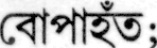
বোপাহঁত;
